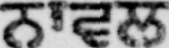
ਨਾਵਲ
